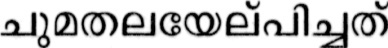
ചുമതലയേല്പിച്ചത്
